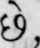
છે,
